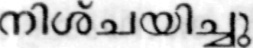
നിശ്ചയിച്ചു
